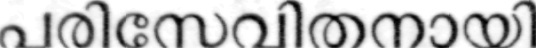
പരിസേവിതനായി
